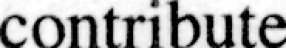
contributed
